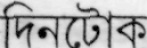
দিনটোক
